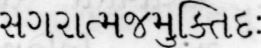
સગરાત્મજમુક્તિદઃ
